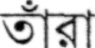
তাঁরা
